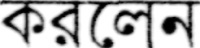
করলেন
